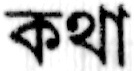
কথা
